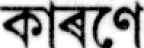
কাৰণে
